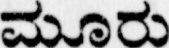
ಮೂರು
